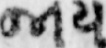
જાય
